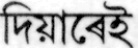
দিয়াৰেই
